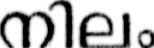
നിലം
